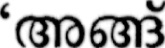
‘അങ്ങ്
